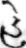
હે
